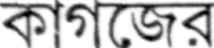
কাগজের
